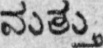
ಮತ್ತು
